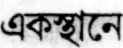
একস্থানে
